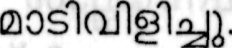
മാടിവിളിച്ചു.
